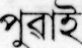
পুৱাই
